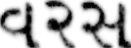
વરસ
